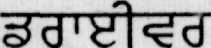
ਡਰਾਈਵਰ
